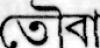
তৌবা
